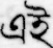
এই
